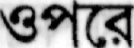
ওপরে
